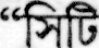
“সিটি
